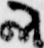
જો
